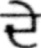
ਦੇ
